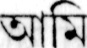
আমি
